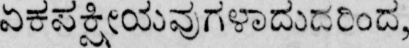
ಏಕಪಕ್ಷೀಯವುಗಳಾದುದರಿಂದ,
